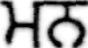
ਮਨ
